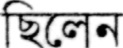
ছিলেন
